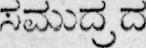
ಸಮುದ್ರದ
